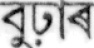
বুঢ়াৰ
